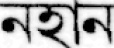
নহন
